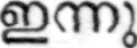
ഇന്നു
